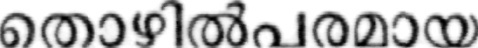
തൊഴില്‍പരമായ
